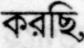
করছি,
